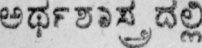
ಅರ್ಥಶಾಸ್ತ್ರದಲ್ಲಿ
